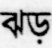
ঝড়
